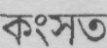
কংসত
